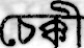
চেক্কী
